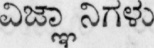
ವಿಜ್ಞಾನಿಗಳು
